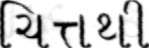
ચિત્તથી
